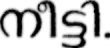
നീട്ടി.
